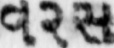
વરસ
